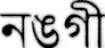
নঙগী
